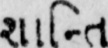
શાન્તિ
